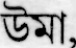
উমা,
